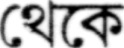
থেকে
